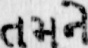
તમને
